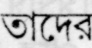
তাদের
